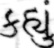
કહ્યું
